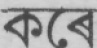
কৰে
